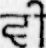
ਵੀ
